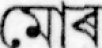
মোৰ
